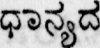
ಧಾನ್ಯದ
